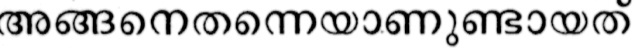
അങ്ങനെതന്നെയാണുണ്ടായത്
